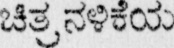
ಚಿತ್ರನಳಿಕೆಯ
